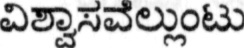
ವಿಶ್ವಾಸವೆಲ್ಲುಂಟು
